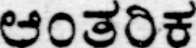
ಆಂತರಿಕ
